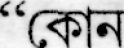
"কোন
